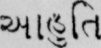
આહુતિ
